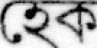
হেক
